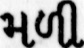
મળી
